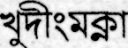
খুদীংমক্না
